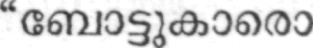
“ബോട്ടുകാരൊ
